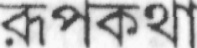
রূপকথা
